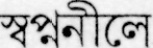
স্বপ্ননীলে
